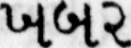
ખબર
